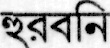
হুরবনি
